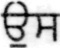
ਉਸ
